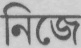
নিজে
